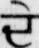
ਦੇ
